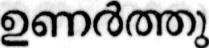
ഉണര്‍ത്തു
